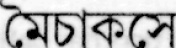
মৈচাকসে
